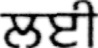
ਲਈ
